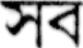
সব
